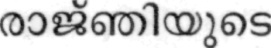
രാജ്ഞിയുടെ
